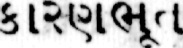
કારણભૂત
